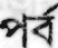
পর্ব
